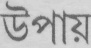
উপায়
